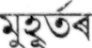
মুহূর্তৰ
